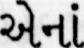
એનાં
